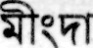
মীংদা
